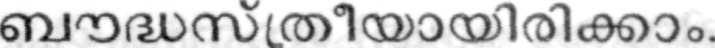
ബൌദ്ധസ്ത്രീയായിരിക്കാം.
